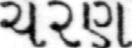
ચરણ
